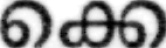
ക്കെ
